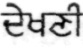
ਦੇਖਣੀ
